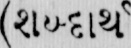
(શબ્દાર્થ
